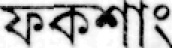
ফকশাং
